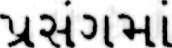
પ્રસંગમાં
